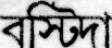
বস্টিদা
